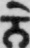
ਨੇ
